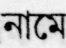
নামে
